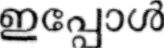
ഇപ്പോള്‍
